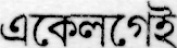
একেলগেই
